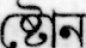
ষ্টোান
